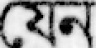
যেন
